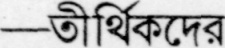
–তীর্থিকদের
